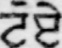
ਟੋਏ
